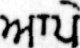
ਆਪੇ
